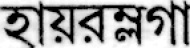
হায়রম্লগা
